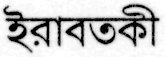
ইরাবতকী
